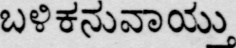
ಬಳಿಕನುವಾಯ್ತು
